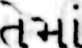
તેમાં
